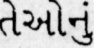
તેઓનું
